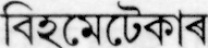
বিহমেটেকাৰ
